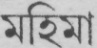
মহিমা
